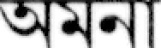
অমনা
